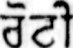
ਰੋਟੀ
